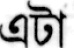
এটা
